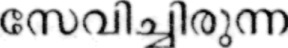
സേവിച്ചിരുന്ന
